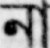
না
